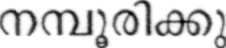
നമ്പൂരിക്കു
